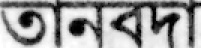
তানবদা
